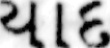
યાદ
